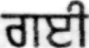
ਗਈ
